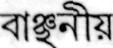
বাঞ্ছনীয়
